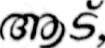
ആട്,
